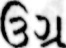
ઉગ્ર
